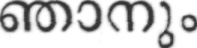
ഞാനും
